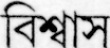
বিশ্বাস
